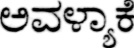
ಅವಳ್ಯಾಕೆ
